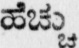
ಹೆಚ್ಚು
